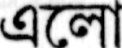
এলো
